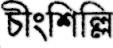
চীংশিল্লি
